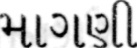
માગણી
